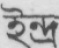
ইন্দ্ৰ
